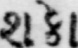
શકો
